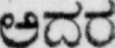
ಅದರ
